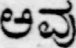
ಅವು
